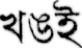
খঙই
